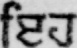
ਇਹ
